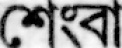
শেংবা
